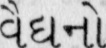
વૈધનો
